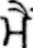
ਮੈਂ
